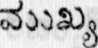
ಮುಖ್ಯ
